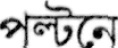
পল্টনে
